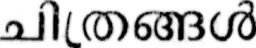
ചിത്രങ്ങള്‍
